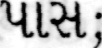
પાસ;
